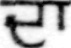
ਦਾ
